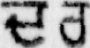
ਦਰ
